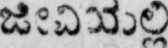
ಜೀವಿಯಲ್ಲಿ
